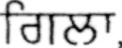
ਗਿਲਾ,
